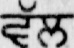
ਵੱਲ
